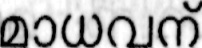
മാധവന്
